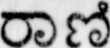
ರಾಣಿ
